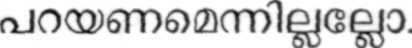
പറയണമെന്നില്ലല്ലോ.
